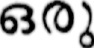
ഒരു
